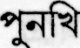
পুনখি
